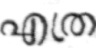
എത്ര
